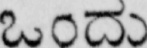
ಒಂದು
